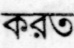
করত
